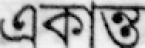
একান্ত
